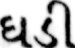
ઘડી
